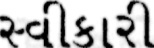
સ્વીકારી
